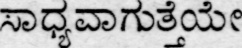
ಸಾಧ್ಯವಾಗುತ್ತೆಯೇ
